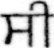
ਸੀ
